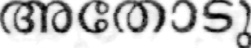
അതോടു
